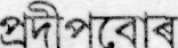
প্ৰদীপবোৰ
